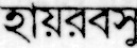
হায়রবসু
